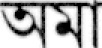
অমা
